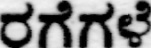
ರಗೆಗಳೆ
